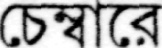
চেম্বারে
